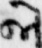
જો
